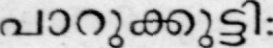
പാറുക്കുട്ടി:
